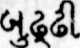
બુઢ્ઢી
